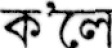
ক'লে
